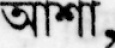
আশা
